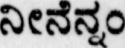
ನೀನೆನ್ನಂ
